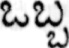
ಒಬ್ಬ
